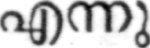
എന്നു
